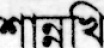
শান্নখি
